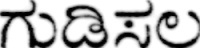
ಗುಡಿಸಲ
